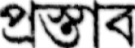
প্রস্তাব
